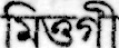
মিত্তগী
